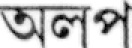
অলপ
